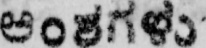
ಅಂಶಗಳು
